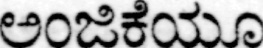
ಅಂಜಿಕೆಯೂ
